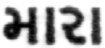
મારા
